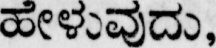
ಹೇಳುವುದು,
